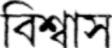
বিশ্বাস
